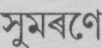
সুমৰণে
